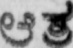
ಆತ
